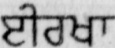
ਈਰਖਾ
